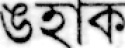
ঙহাক
